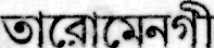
তারোমেনগী
